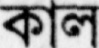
কাল
